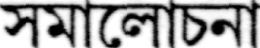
সমালোচনা
